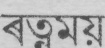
ৰত্নময়
